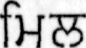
ਮਿਲ
